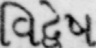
વિદ્વેષ
